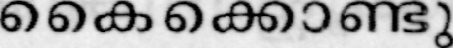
കൈക്കൊണ്ടു
